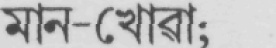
মান-খোৱা;
